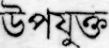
উপযুক্ত
